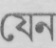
যেন
